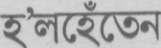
হ'লহেঁতেন
